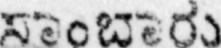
ಸಾಂಬಾರು
